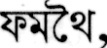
ফমথৈ,
